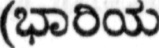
(ಭಾರಿಯ
